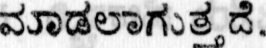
ಮಾಡಲಾಗುತ್ತದೆ.
